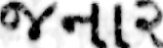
જનાર
